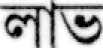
লাভ
